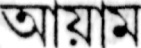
আয়াম
